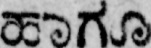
ಹಾಗೂ
